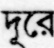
দূরে
